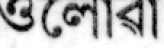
ওলোৱা
